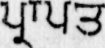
ਪ੍ਰਾਪਤ
